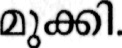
മുക്കി.
